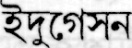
ইদুগেসন
